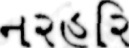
નરહરિ
